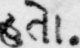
હતો.
